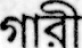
গারী
